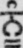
ਨੂੰ
